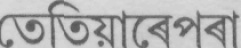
তেতিয়াৰেপৰা
